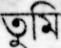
তুমি
